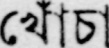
খোঁচা
